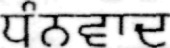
ਧੰਨਵਾਦ
